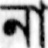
না
